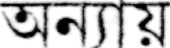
অন্যায়
